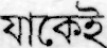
যাকেই
